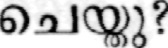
ചെയ്തു?
